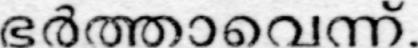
ഭര്‍ത്താവെന്ന്.
